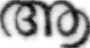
ആ
